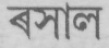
ৰসাল
